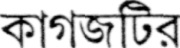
কাগজটির
